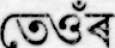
তেওঁৰ
